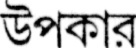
উপকার
